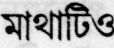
মাথাটিও
